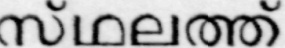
സ്ഥലത്ത്
